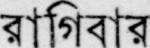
রাগিবার
